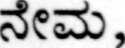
ನೇಮ,
